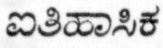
ಐತಿಹಾಸಿಕ
